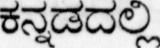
ಕನ್ನಡದಲ್ಲಿ
